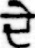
ਦੇ
